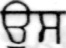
ਉਸ
